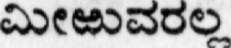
ಮೀಱುವರಲ್ಲ
